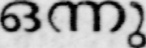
ഒന്നു
